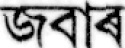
জবাৰ
